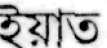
ইয়াত
